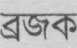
ব্ৰজক
